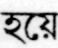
হয়ে
